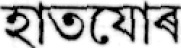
হাতযোৰ
